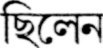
ছিলেন
